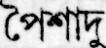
পৈশৈদু
